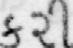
કરી
